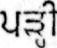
ਪੜ੍ਹੀ
